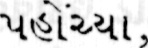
પહોંચ્યા,
